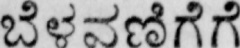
ಬೆಳವಣಿಗೆಗೆ
